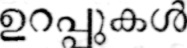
ഉറപ്പുകള്‍
